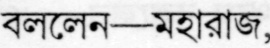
বললেন–মহারাজ,
